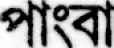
পাংবা
